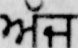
ਅੱਜ
